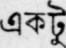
একটু
